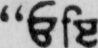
''ਓਇ
